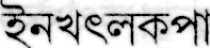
ইনখৎলকপা
